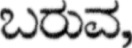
ಬರುವ,
